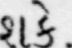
શકે.
